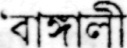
বাঙ্গালী
